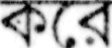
করে
